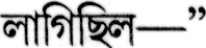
লাগিছিল-"
